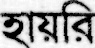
হায়রি
